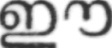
ഈ
